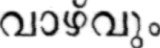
വാഴ്വും
